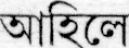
আহিলে
